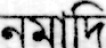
নমাদি
